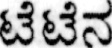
ಟೆಟೆನ
